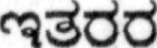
ಇತರರ
